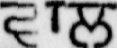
ਵਾਲ
